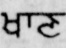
ਖਾਣ
